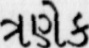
ત્રણેક
